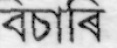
বিচাৰি
